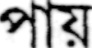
পায়
